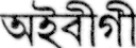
অইবীগী
